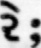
રે;
